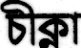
চীক্না
